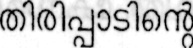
തിരിപ്പാടിന്റെ
